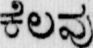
ಕೆಲವು
